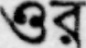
ওর
